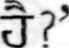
ਹੈ?'
